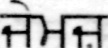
ਜੇਮਜ਼
